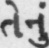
તેનું
